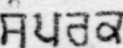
ਸੰਪਰਕ
